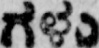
ಗಳು
